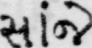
સાંજે
